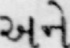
અને
